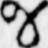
જ
